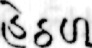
હેઠળ
